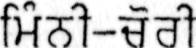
ਮਿੰਨੀ-ਚੋਰੀ
